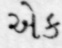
એક
